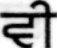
ਵੀ
